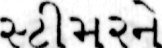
સ્ટીમરને
